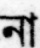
না
